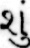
શું
